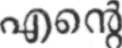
എന്റെ
